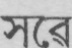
সৱে
